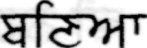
ਬਣਿਆ
